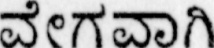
ವೇಗವಾಗಿ
